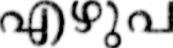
എഴുപ
